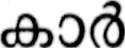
കാര്‍
